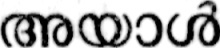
അയാള്‍
